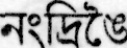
নংদ্রিঙৈ
